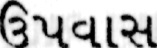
ઉપવાસ
